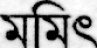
মমিৎ
